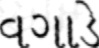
વગાડે
